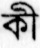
কী
